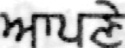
ਆਪਣੇ
